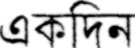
একদিন
